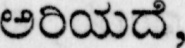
ಅರಿಯದೆ,
